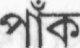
পাঁক
